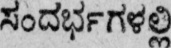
ಸಂದರ್ಭಗಳಲ್ಲಿ
